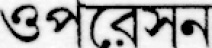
ওপরেসন
